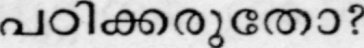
പഠിക്കരുതോ?
